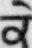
ਕੇ
